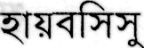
হায়বসিসু
